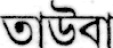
তাউবা
